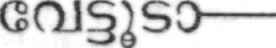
വേട്ടൂടാ-
